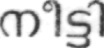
നീട്ടി
